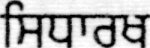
ਸਿਧਾਰਥ
